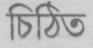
চিঠিত
